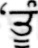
'ਤੂੰ
